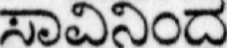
ಸಾವಿನಿಂದ
